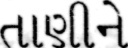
તાણીને
